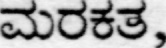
ಮರಕತ,
